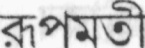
রূপমতী
